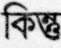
কিন্তু
